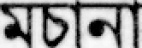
মচানা
